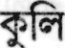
কুলি
